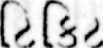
ટિકિટ
